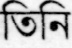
তিনি
